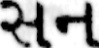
સન
